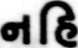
નહિ
